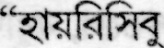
“হায়রিসিবু
